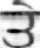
ਤੇ
